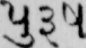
પુરૂષ
